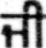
ਜੀ
